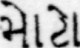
મોટો
